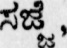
ಸಜ್ಜೆ,
